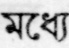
মধ্যে
